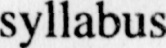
syllabus
